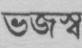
ভজস্ব
